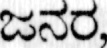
ಜನರ,
